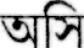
অসি
